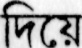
দিয়ে
